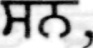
ਸਨ,
